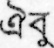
ঐবু
